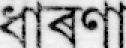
ধাৰণা
